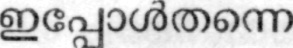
ഇപ്പോള്‍തന്നെ
